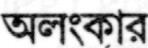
অলংকার
